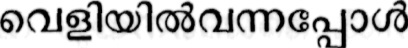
വെളിയില്‍വന്നപ്പോള്‍
